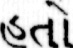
હતો
